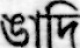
ঙাদি
